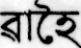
ৱাহৈ
